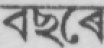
বছৰে
